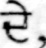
ਦੇ,
